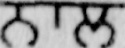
ਨਾਲ
